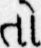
તો
